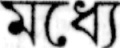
মধ্যে
